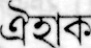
ঐহাক
